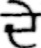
ਦੇ
